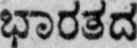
ಭಾರತದ
